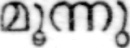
മൂന്നു
